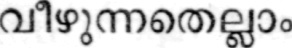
വീഴുന്നതെല്ലാം
